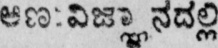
ಅಣುವಿಜ್ಞಾನದಲ್ಲಿ
